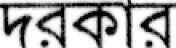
দরকার
